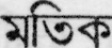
মতিক
